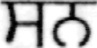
ਸਨ
